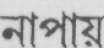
নাপায়
